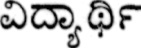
ವಿದ್ಯಾರ್ಥಿ
